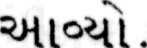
આવ્યો.
